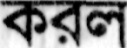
করল
